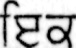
ਇਕ
